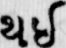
થઈ
